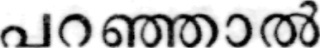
പറഞ്ഞാല്‍
